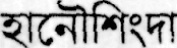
হানৌশিংদা
